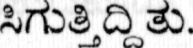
ಸಿಗುತ್ತಿದ್ದಿತು.
